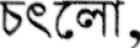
চৎলো,
